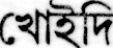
খোইদি
